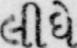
લીધે
